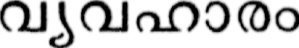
വ്യവഹാരം
